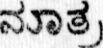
ಮಾತ್ರ
